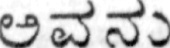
ಅವನು
